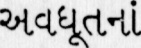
અવધૂતનાં
